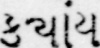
ક્યાંય
